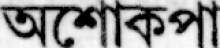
অশোকপা
